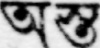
অস্ত
